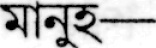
মানুহ-
